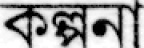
কল্পনা
